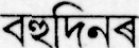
বহুদিনৰ
